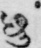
છું
